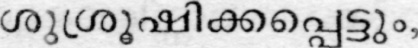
ശുശ്രൂഷിക്കപ്പെട്ടും,
